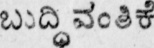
ಬುದ್ದಿವಂತಿಕೆ
